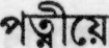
পত্নীয়ে
